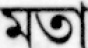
মতা
